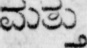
ಮತ್ತು
